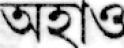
অহাও
